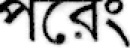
পরেং
